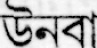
উনবা
